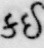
કઈ
